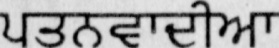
ਪਤਨਵਾਦੀਆ
